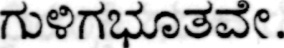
ಗುಳಿಗಭೂತವೇ.
